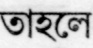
তাহলে
